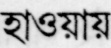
হাওয়ায়
